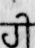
ਹੀ
